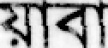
য়াবা
